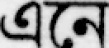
এনে
